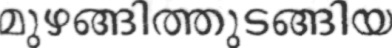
മുഴങ്ങിത്തുടങ്ങിയ
